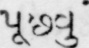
પૂછવું
